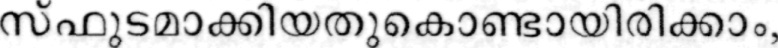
സ്ഫുടമാക്കിയതുകൊണ്ടായിരിക്കാം,
